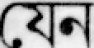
যেন
